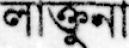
লাক্তুনা
